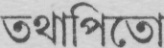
তথাপিতো
